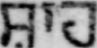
ਸ਼ਾਹ
